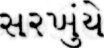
સરખુંયે
